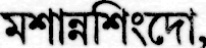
মশান্নশিংদো,
